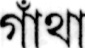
গাঁথা
